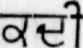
ਕਦੀ
